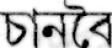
চানবৈ
